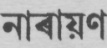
নাৰায়ণ
